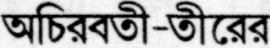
অচিরবতী-তীরের
